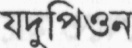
যদুপিওন
